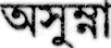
অসুম্না
